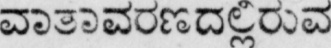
ವಾತವರಣದಲ್ಲಿರುವ
